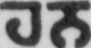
ਹਨ
